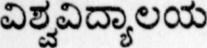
ವಿಶ್ವವಿದ್ಯಾಲಯ
